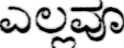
ಎಲ್ಲವೂ
